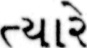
ત્યારે
